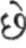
છે
